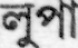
লুপা
